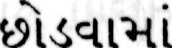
છોડવામાં
